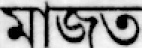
মাজত
